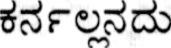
ಕರ್ನಲ್ಲನದು
